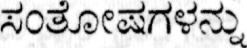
ಸಂತೋಷಗಳನ್ನು
